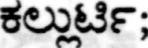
ಕಲ್ಲುರ್ಟಿ;
